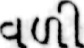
વળી
